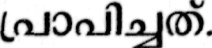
പ്രാപിച്ചത്.
